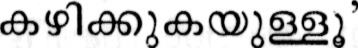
കഴിക്കുകയുള്ളൂ’
